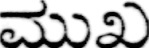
ಮುಖ
